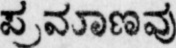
ಪ್ರಮಾಣವು
